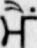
ਮੈਂ
